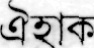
ঐহাক
